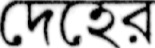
দেহের
